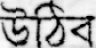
উঠিব
